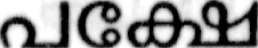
പക്ഷേ
